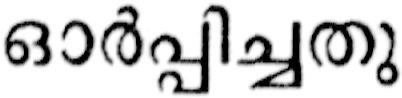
ഓര്‍പ്പിച്ചതു
